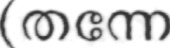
(തന്നേ
